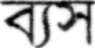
ব্যস
